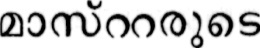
മാസ്ററരുടെ
